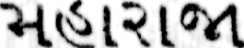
મહારાજા
